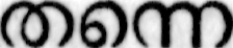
തന്നെ
